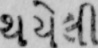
થયેલી
